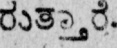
ರುತ್ತಾರೆ.
